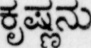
ಕೃಷ್ಣನು
